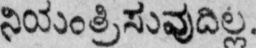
ನಿಯಂತ್ರಿಸುವುದಿಲ್ಲ.
